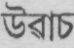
উৱাচ
